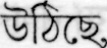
উঠিছে,
